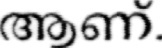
ആണ്.
